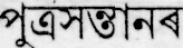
পুত্রসন্তানৰ
